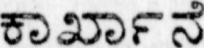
ಕಾರ್ಖಾನೆ
